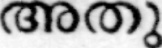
അതു
